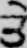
ਤੇ
